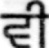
ਵੀ
